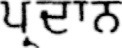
ਪ੍ਰਦਾਨ
